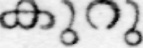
കുറു
